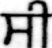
ਸੀ
